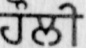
ਹੌਲੀ
